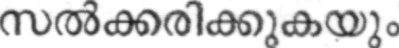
സല്‍ക്കരിക്കുകയും
